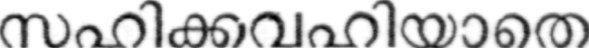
സഹിക്കവഹിയാതെ
